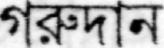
গরুদান
